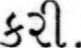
કરી.
